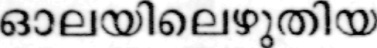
ഓലയിലെഴുതിയ
